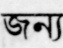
জন্য
